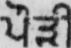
ਪੌੜੀ
